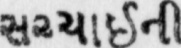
સચ્ચાઈની
